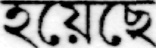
হয়েছে
